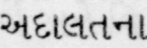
અદાલતના
